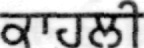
ਕਾਹਲੀ
